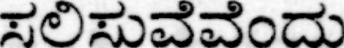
ಸಲಿಸುವೆವೆಂದು
